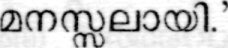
മനസ്സലായി.’
